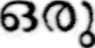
ഒരു
